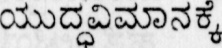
ಯುದ್ಧವಿಮಾನಕ್ಕೆ
